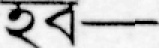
হব-
